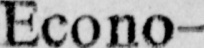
Econo-
